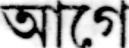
আগে
